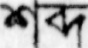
শব্দ
